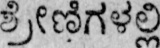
ಶ್ರೇಣಿಗಳಲ್ಲಿ
